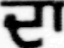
ਦਾ
